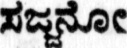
ಸಜ್ಜನೋ
